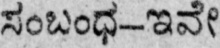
ಸಂಬಂಧ-ಇವೇ
